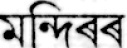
মন্দিৰৰ
